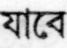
যাবে
